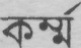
কৰ্ম্ম
